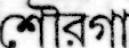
শৌরগা
